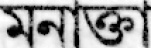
মনাক্তা
